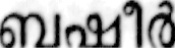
ബഷീര്‍
